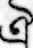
ঐ
